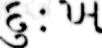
દુઃખ
